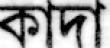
কাদা
